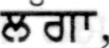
ਲੱਗਾ,
